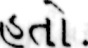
હતો.
